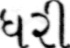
ધરી
